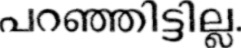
പറഞ്ഞിട്ടില്ല.
